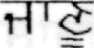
ਜਾਣੂ
